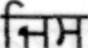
ਜਿਸ
